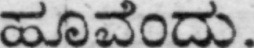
ಹೂವೆಂದು.
